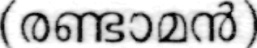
(രണ്ടാമന്‍)
